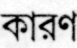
কারণ
